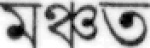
মঞ্চত
